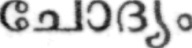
ചോദ്യം
